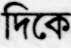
দিকে
